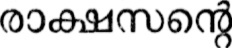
രാക്ഷസന്റെ
